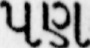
પણ
